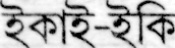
ইকাই-ইকি
